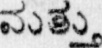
ಮತ್ತು
